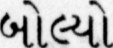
બોલ્યો
